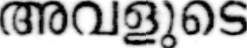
അവളുടെ
